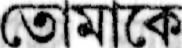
তোমাকে
